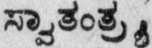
ಸ್ವಾತಂತ್ರ್ಯ
